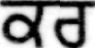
ਕਰ
